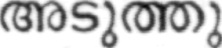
അടുത്തു
